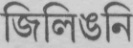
জিলিঙনি
